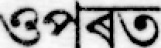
ওপৰত
